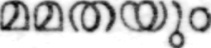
മമതയും
